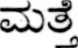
ಮತ್ತೆ
